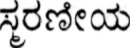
ಸ್ಮರಣೀಯ
